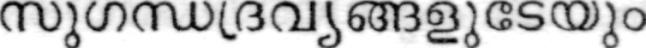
സുഗന്ധദ്രവ്യങ്ങളുടേയും
